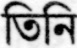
তিনি
